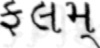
ફલમ્
